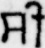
ਸੀ
